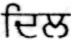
ਦਿਲ
